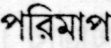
পরিমাপ
